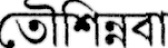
তৌশিন্নবা
